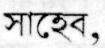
সাহেব,
